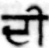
ਦੀ
